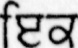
ਇਕ
